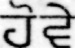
ਹੋਵੇ
